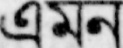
এমন
